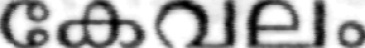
കേവലം
